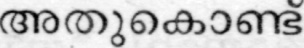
അതുകൊണ്ട്
